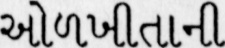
ઓળખીતાની
